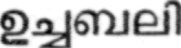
ഉച്ചബലി
